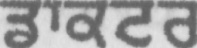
ਡਾਕਟਰ
